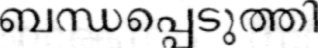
ബന്ധപ്പെടുത്തി
